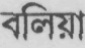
বলিয়া
